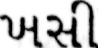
ખસી
